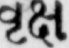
વૃક્ષ
